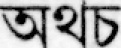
অথচ
